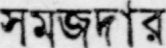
সমজদার
